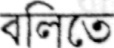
বলিতে
